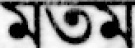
মতম
